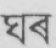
ঘৰ
